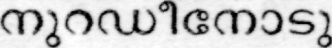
നുറഡീനോടു
